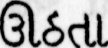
ઊઠતા
